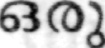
ഒരു
